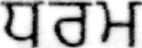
ਧਰਮ
